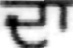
ਦਾ
